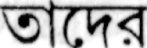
তাদের
